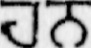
ਹਨ
